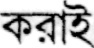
করাই
